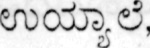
ಉಯ್ಯಾಲೆ,
